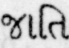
જાતિ
